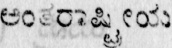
ಅಂತರಾಷ್ಟ್ರೀಯ
